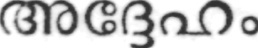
അദ്ദേഹം
